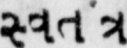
સ્વતંત્ર
